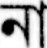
না
